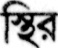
স্থির
